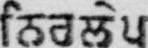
ਨਿਰਲੇਪ
